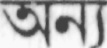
অন্য
